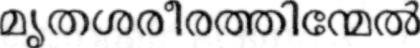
മൃതശരീരത്തിന്മേല്‍
